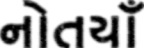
નોતર્યા
